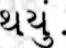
થયું.
